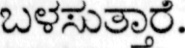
ಬಳಸುತ್ತಾರೆ.
